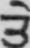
ਤੇ
